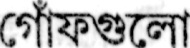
গোঁফগুলো
